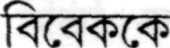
বিবেককে
